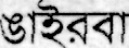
ঙাইরবা
